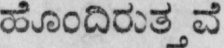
ಹೊಂದಿರುತ್ತವೆ
